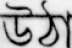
উঠা
